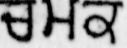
ਚਮਕ
